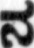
ನ
